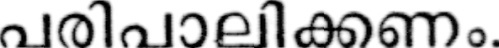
പരിപാലിക്കണം.
